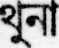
থুনা
